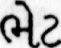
ભેટ
